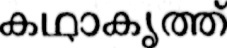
കഥാകൃത്ത്
